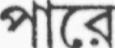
পারে
